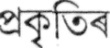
প্রকৃতিৰ
